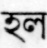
হল
